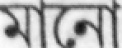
মানো
